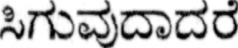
ಸಿಗುವುದಾದರೆ
